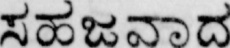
ಸಹಜವಾದ
